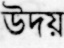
উদয়
